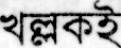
খল্লকই
